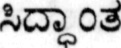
ಸಿದ್ಧಾಂತ
